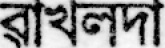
ৱাখলদা
